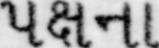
પક્ષના
